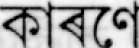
কাৰণে
